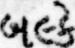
બલ્કે
